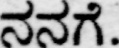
ನನಗೆ.
